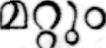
മറ്റും
